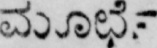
ಮೂರ್ಛೆ
